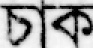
চাক
